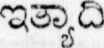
ಇತ್ಯಾದಿ
